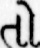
તો
